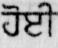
ਹੋਈ
